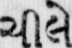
ચીલે
